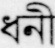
ধনী
